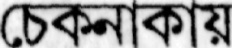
চেকনাকায়
